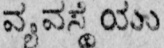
ವ್ಯವಸ್ಥೆಯು
